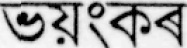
ভয়ংকৰ
